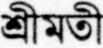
শ্রীমতী
